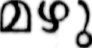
മഴു
